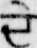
ਦੇ
